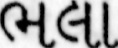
ભલા
